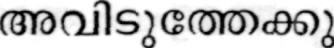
അവിടുത്തേക്കു
